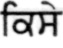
ਕਿਸੇ
